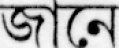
জানে
